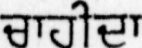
ਚਾਹੀਦਾ
